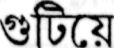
গুটিয়ে
